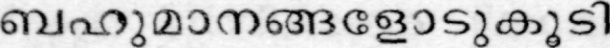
ബഹുമാനങ്ങളോടുകൂടി
